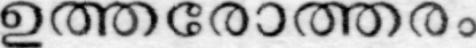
ഉത്തരോത്തരം
